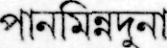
পানমিন্নদুনা
